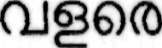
വളരെ
